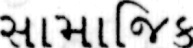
સામાજિક
